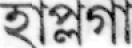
হাপ্লগা
